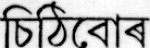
চিঠিবোৰ
